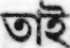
তাই
